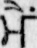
ਮੈਂ
